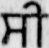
ਸੀ
